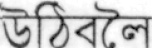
উঠিবলৈ
